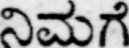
ನಿಮಗೆ
